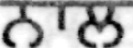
ਨਾਲ
